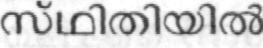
സ്ഥിതിയില്‍
